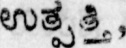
ಉತ್ಪತ್ತಿ,
